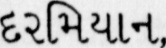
દરમિયાન,
